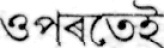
ওপৰতেই
